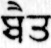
ਬੈਤ
